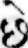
છે
